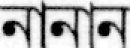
নানান
